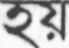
হয়
